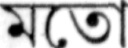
মতো
